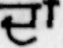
ਦਾ
